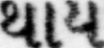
થાય
